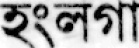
হংলগা
